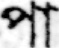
পা
